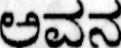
ಅವನ
